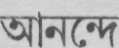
আনন্দে
